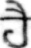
ਹੈ
